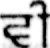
ਵੀ
